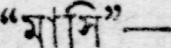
‘‘মাসি’’—
